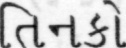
તિનકો
